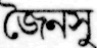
জৈনসু
